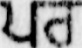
ਪਰ
